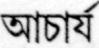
আচার্য
